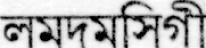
লমদমসিগী
